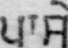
ਪਾਸੇ
